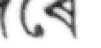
দৰে
